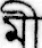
মী
